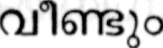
വീണ്ടും
